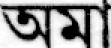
অমা
